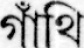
গাঁথি
